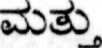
ಮತ್ತು
